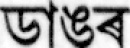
ডাঙৰ
